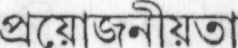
প্রয়োজনীয়তা
